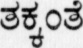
ತಕ್ಕಂತೆ
